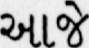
આજે
